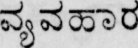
ವ್ಯವಹಾರ
